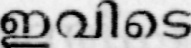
ഇവിടെ
